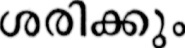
ശരിക്കും
